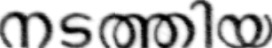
നടത്തിയ
